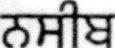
ਨਸੀਬ
